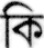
কি
